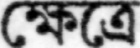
ক্ষেত্রে
